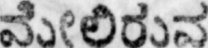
ಮೇಲಿರುವ
